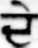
ਦੇ
